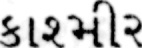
કાશ્મીર
